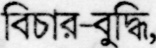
বিচার-বুদ্ধি,
